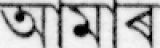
আমাৰ
